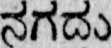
ನಗದು
